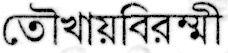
তৌখায়বিরম্মী
